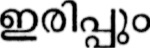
ഇരിപ്പും
